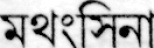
মথংসিনা
